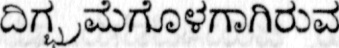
ದಿಗ್ಭ್ರುಮೆಗೊಳಗಾಗಿರುವ
